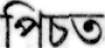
পিচত
